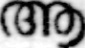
ആ
